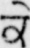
ਕੇ
